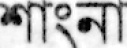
শাংনা
